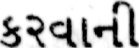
કરવાની
